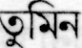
তুমিন
